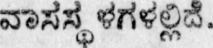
ವಾಸಸ್ಥಳಗಳಲ್ಲಿದೆ.
